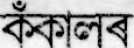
কঁকালৰ
